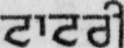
ਟਾਟਰੀ
